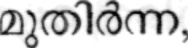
മുതിര്‍ന്ന,
